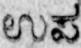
ಉಪ
